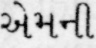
એમની
